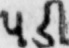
પડી
